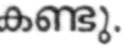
കണ്ടു.
